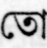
তো
